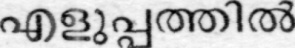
എളുപ്പത്തില്‍
